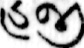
હજી
